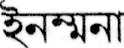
ইনম্মনা
